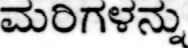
ಮರಿಗಳನ್ನು
